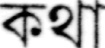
কথা
